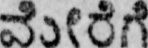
ಮೇರೆಗೆ
